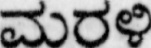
ಮರಳಿ
